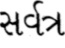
સર્વત્ર
